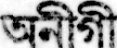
অনীগী
